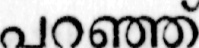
പറഞ്ഞ്
